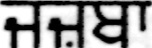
ਜਜ਼ਬਾ
